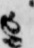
હું
